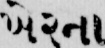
ખેરના
